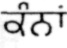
ਕੰਨਾਂ
